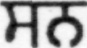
ਸਨ
